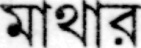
মাথার
